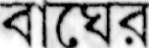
বাঘের
